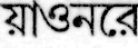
য়াওনরে
